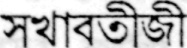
সখাবতীজী
